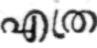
എത്ര
